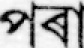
পৰা
